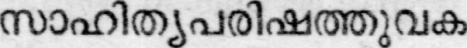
സാഹിത്യപരിഷത്തുവക
